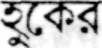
হুকের
